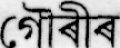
গৌৰীৰ
